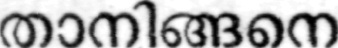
താനിങ്ങനെ
